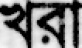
খরা
